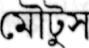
মৌটুস
